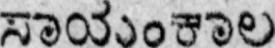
ಸಾಯಂಕಾಲ
